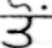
ਤੋਂ
